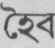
হৈব
